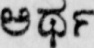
ಅರ್ಥ
